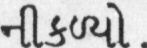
નીકળ્યો.
